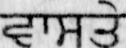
ਵਾਸਤੇ
